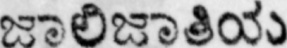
ಜಾಲಿಜಾತಿಯ
